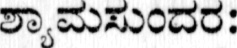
ಶ್ಯಾಮಸುಂದರ:
